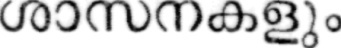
ശാസനകളും
